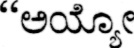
"ಅಯ್ಯೋ
